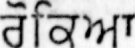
ਰੋਕਿਆ
